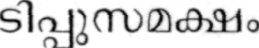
ടിപ്പുസമക്ഷം
